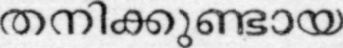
തനിക്കുണ്ടായ
